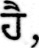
ਹੈ,
